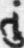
તું
